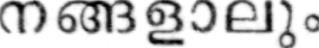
നങ്ങളാലും
